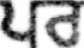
ਪਰ
